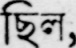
ছিল,
